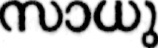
സാധു
